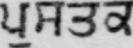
ਪੁਸਤਕ
